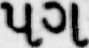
પગ
